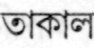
তাকাল
